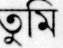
তুমি
